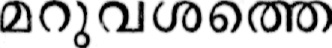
മറുവശത്തെ
